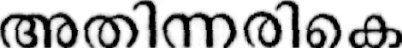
അതിന്നരികെ
